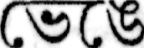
ভেঙে
